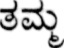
ತಮ್ಮ
